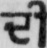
ਦੀ
